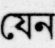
যেন
